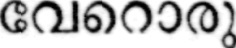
വേറൊരു
